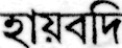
হায়বসি
